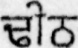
ਢੀਠ
